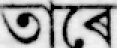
তাৰে
